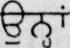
ਉਨ੍ਹਾਂ
